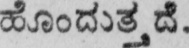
ಮಾರ್ಕ್ಸ್
